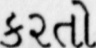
કરતો
